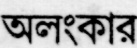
অলংকার
